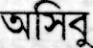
অসিবু
